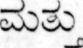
ಮತ್ತು
